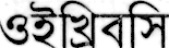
ওইখ্রিবসি
